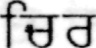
ਚਿਰ
